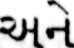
અને
